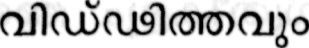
വിഡ്ഢിത്തവും
